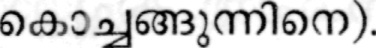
കൊച്ചങ്ങുന്നിനെ).
